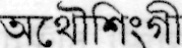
অথৌশিংগী
